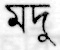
মদু
